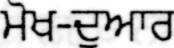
ਮੋਖ-ਦੁਆਰ
